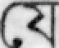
যে
